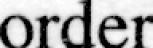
order
